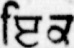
ਇਕ
